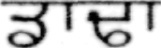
ਡਾਢਾ
